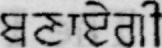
ਬਣਾਏਗੀ
